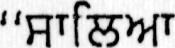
''ਸਾਲਿਆ
